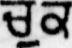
ਚੁਕ
